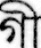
গী
